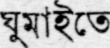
ঘুমাইতে
